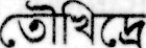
তৌখিদ্রে
